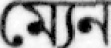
ম্যেন
